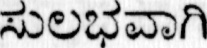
ಸುಲಭವಾಗಿ
